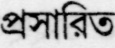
প্রসারিত
